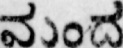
ಮಂದ
